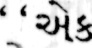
"એક
